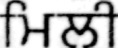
ਮਿਲੀ
